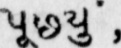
પૂછ્યું,
